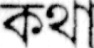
কথা
